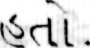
હતો.
